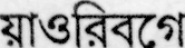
য়াওরিবগে
